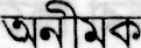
অনীমক
